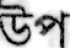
উপ
